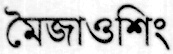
মৈজাওশিং
